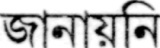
জানায়নি
